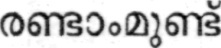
രണ്ടാംമുണ്ട്
